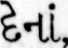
દેનાં,
